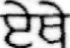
ਏਥੇ
